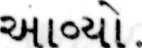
આવ્યો.
